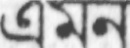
এমন
